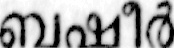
ബഷീര്‍
